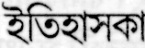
ইতিহাসকা
